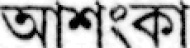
আশংকা
